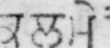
ਕਲਮੇਂ
